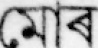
মোৰ
